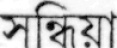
সন্ধিয়া
